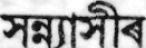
সন্ন্যাসীৰ
